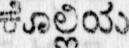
ಕೊಲ್ಲಿಯ
